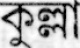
কুল্লা
